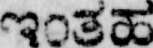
ಇಂತಹ
